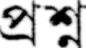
প্রশ্ন
